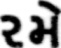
રમે
